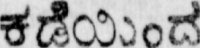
ಕಡೆಯಿಂದ
